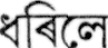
ধৰিলে
